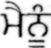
ਮੈਨੂੰ
